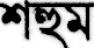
শহুম
